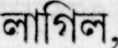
লাগিল,
